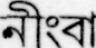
নীংবা
